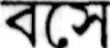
বসে
